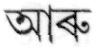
আৰু
